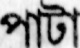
পাটা
